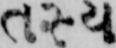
તસ્ય
